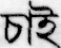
চাই
